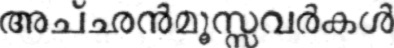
അച്ഛന്‍മൂസ്സവര്‍കള്‍
